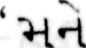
'મને
